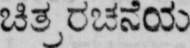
ಚಿತ್ರರಚನೆಯ
